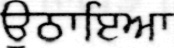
ਉਠਾਇਆ
